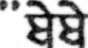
''ਬੇਬੇ
